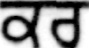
ਕਰ
